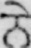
ਨੇ
